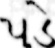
પડે
